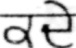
ਕਦੇ
